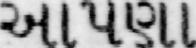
આપણા
